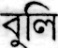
বুলি
